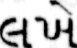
લખે
